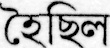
হৈছিল
